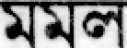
মমল
